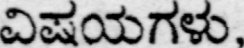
ವಿಷಯಗಳು,
